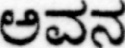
ಅವನ
